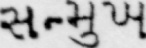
સન્મુખ
